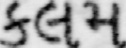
કલમ
